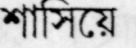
শাসিয়ে
